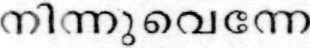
നിന്നുവെന്നേ
